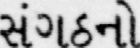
સંગઠનો
